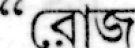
“রোজ
